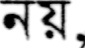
নয়,
